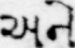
અને
